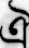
ঐ
